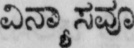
ವಿನ್ಯಾಸವೂ
